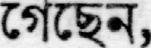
গেছেন,
